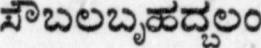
ಸೌಬಲಬೃಹದ್ಬಲಂ
